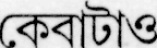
কেবাটাও
